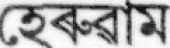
হেৰুৱাম
